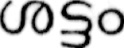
ശട്ടം
